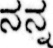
ನನ್ನ
